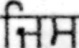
ਜਿਸ
